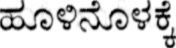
ಹೂಳಿನೊಳಕ್ಕೆ
